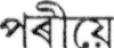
পৰীয়ে
